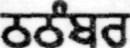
ਠਠੰਬਰ
